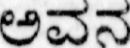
ಅವನ
